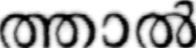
ത്താല്‍
